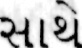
સાથે
